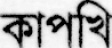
কাপখি
